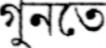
গুনতে
